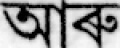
আৰু
